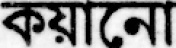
কয়ানো
